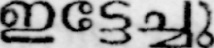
ഇട്ടേച്ചു
